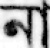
না
